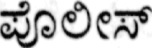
ಪೊಲೀಸ್
